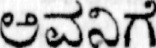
ಅವನಿಗೆ
